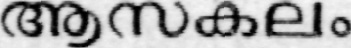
ആസകലം
